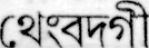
থেংবদগী
